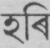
হৰি
